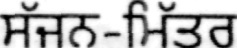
ਸੱਜਨ-ਮਿੱਤਰ
